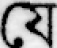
যে
